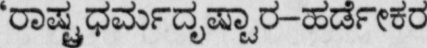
‘ರಾಷ್ಟ್ರಧರ್ಮದೃಷ್ಟಾರ-ಹರ್ಡೇಕರ
